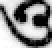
ও
